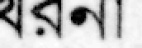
খরনা
